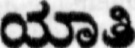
ಯಾತಿ
